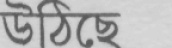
উঠিছে
